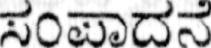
ಸಂಪಾದನೆ
